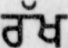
ਰੱਖ
